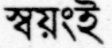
স্বয়ংই
